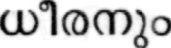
ധീരനും
